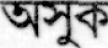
অসুক
